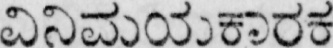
ವಿನಿಮಯಕಾರಕ
